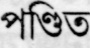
পণ্ডিত
